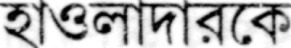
হাওলাদারকে
